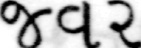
જ્વર
